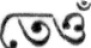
তেওঁ
